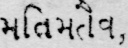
મતિમતૈવ,
